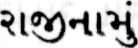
રાજીનામું
